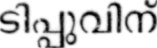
ടിപ്പുവിന്
